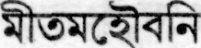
মীতমহৌবনি
